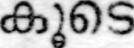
കൂടെ
